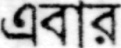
এবার
